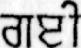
ਗਈ
